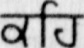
ਕਹਿ
